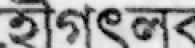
শোয়দনা
